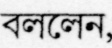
বললেন,
